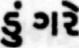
ડુંગરે
